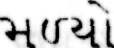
મળ્યો
